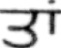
ਤਾਂ
